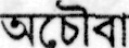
অচৌবা
